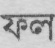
ফল
